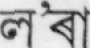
ল'ৰা
